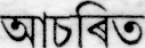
আচৰিত
